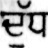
ਦੁੱਧ
